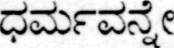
ಧರ್ಮವನ್ನೇ
